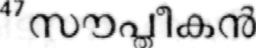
47സൌപ്തീകന്‍
